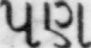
પણ
